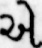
એ
